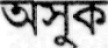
অসুক
